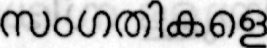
സംഗതികളെ
